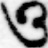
ও
